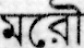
মরৌ
